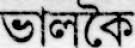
ভালকৈ
